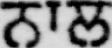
ਨਾਲ
